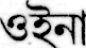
ওইনা
